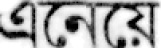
এনেয়ে
